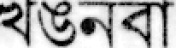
খঙনবা
